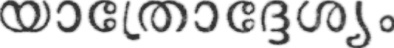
യാത്രോദ്ദേശ്യം
